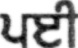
ਪਈ
